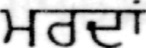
ਮਰਦਾਂ
